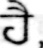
ਹੈ,
